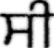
ਸੀ
